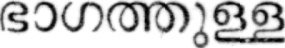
ഭാഗത്തുള്ള
